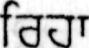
ਰਿਹਾ
